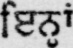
ਇਨ੍ਹਾਂ
